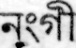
নংগী
